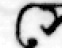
সে
